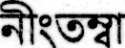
নীংতম্বা
